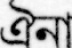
ঐনা
